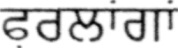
ਫ਼ਰਲਾਂਗਾਂ
